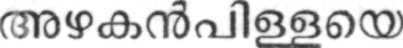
അഴകന്‍പിള്ളയെ
